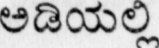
ಅಡಿಯಲ್ಲಿ
